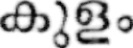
കുളം
